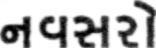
નવસરો
